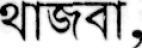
থাজবা,
